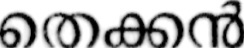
തെക്കന്‍
